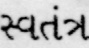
સ્વતંત્ર
